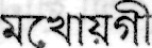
মখোয়গী
